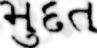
મુદત
